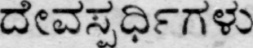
ದೇವಸ್ಪರ್ಧಿಗಳು
